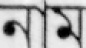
নাম
